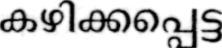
കഴിക്കപ്പെട്ട
